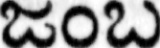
ಜಂಬ
